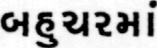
બહુચરમાં
